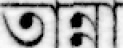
তান্না
